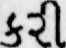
કરી
